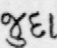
જુદા
